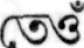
তেওঁ
